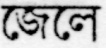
জেলে
